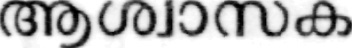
ആശ്വാസക
